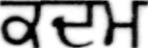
ਕਦਮ
